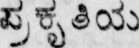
ಪ್ರಕೃತಿಯ
